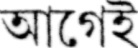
আগেই
